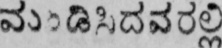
ಮಂಡಿಸಿದವರಲ್ಲಿ
